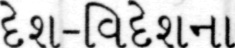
દેશ-વિદેશના
